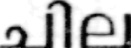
ചില
